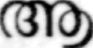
ആ
